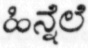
ಹಿನ್ನಲೆ
